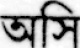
অসি
